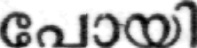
പോയി
